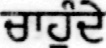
ਚਾਹੁੰਦੇ
